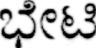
ಭೇಟಿ
